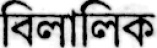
বিলালিক
